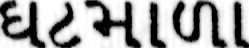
ઘટમાળા
